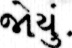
જોયું.
